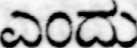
ಎಂದು
